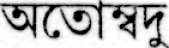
অতোম্বদু
